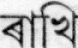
ৰাখি
